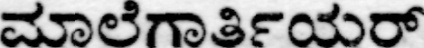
ಮಾಲೆಗಾರ್ತಿಯರ್
